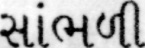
સાંભળી
